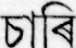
চাৰি
